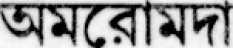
অমরোমদা
